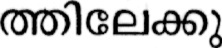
ത്തിലേക്കു
